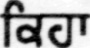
ਕਿਹਾ
